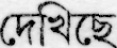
দেখিছে
